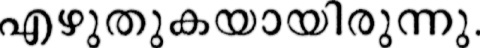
എഴുതുകയായിരുന്നു.
